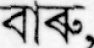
বাৰু,
